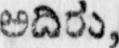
ಅದಿರು,
